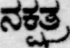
ನಕ್ಷತ್ರ
